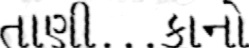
તાણી...કાનો
